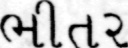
ભીતર
